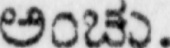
ಅಂಚು.
